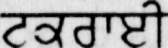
ਟਕਰਾਈ
